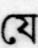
যে
